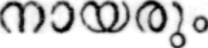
നായരും
